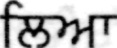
ਲਿਆ
